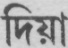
দিয়া
